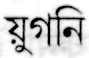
য়ুগনি
